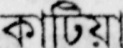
কাটিয়া
